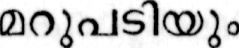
മറുപടിയും
